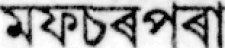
মফচৰপৰা
